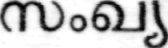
സംഖ്യ
